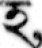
হ,
